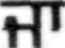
ਜਾ
